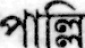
পাল্লি
